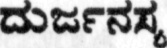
ದುರ್ಜನಸ್ಯ
